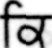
ਕਿ
